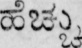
ಹೆಚ್ಚು
